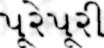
પૂરેપૂરી
